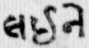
લઈને
